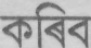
কৰিব
